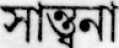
সান্ত্বনা
